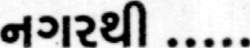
નગરથી..........
